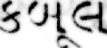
કબૂલ
